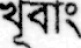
খূবাং
